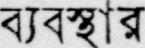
ব্যবস্থার
